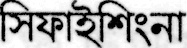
সিফাইশিংনা
